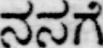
ನನಗೆ
